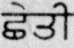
ਛੇਤੀ
